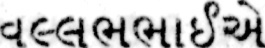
વલ્લભભાઈએ
